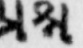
પ્રશ્ન
